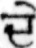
ਦੇ
